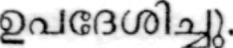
ഉപദേശിച്ചു.
